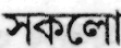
সকলো
